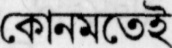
কোনমতেই
